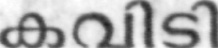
കവിടി
